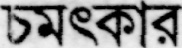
চমৎকার
